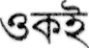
ওকই
